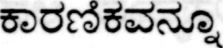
ಕಾರಣಿಕವನ್ನೂ
